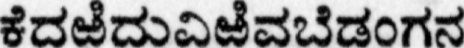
ಕೆದಱದುವಿಱವಬೆಡಂಗನ
